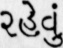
રહેવું
